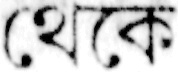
থেকে
